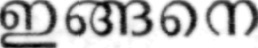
ഇങ്ങനെ
